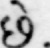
છે.
